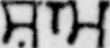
ਸ਼ਾਮ
